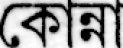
কোন্না
